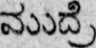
ಮುದ್ರೆ
